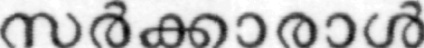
സര്‍ക്കാരാള്‍
